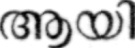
ആയി
